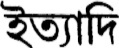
ইত্যাদি
